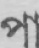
পা
